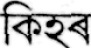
কিহৰ
